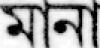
মানা
